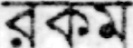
রকম
